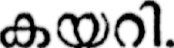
കയറി.
